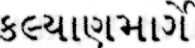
કલ્યાણમાર્ગે
